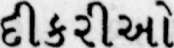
દીકરીઓ
